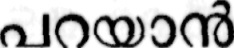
പറയാന്‍
